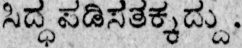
ಸಿದ್ಧಪಡಿಸತಕ್ಕದ್ದು.
